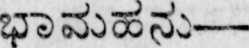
ಭಾಮಹನು-
